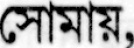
সোমায়,
